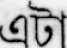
এটা
